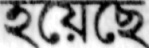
হয়েছে
